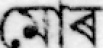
মোৰ
